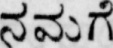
ನಮಗೆ
